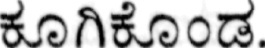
ಕೂಗಿಕೊಂಡ.
